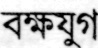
বক্ষযুগ
